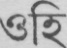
ওহি
